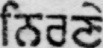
ਨਿਰਣੇ
